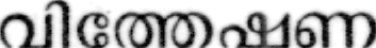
വിത്തേഷണ
